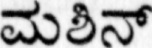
ಮಶಿನ್
